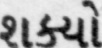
શક્યો
